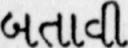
બતાવી
